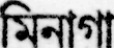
মিনাগা
